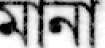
মানা
